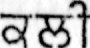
ਕਲੀ
